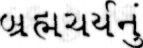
બ્રહ્મચર્યનું
